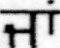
ਜਾਂ
